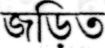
জড়িত
